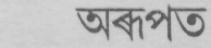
অৰূপত
